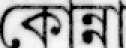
কোন্না
